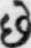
છે
